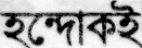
হন্দোকই
